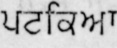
ਪਟਕਿਆ
